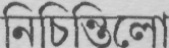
নিচিন্তিলো
